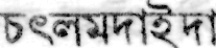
চৎলমদাইদা
